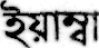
ইয়াম্বা
